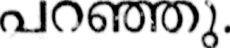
പറഞ്ഞു.
